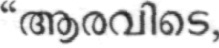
“ആരവിടെ,
